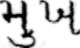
મુખ
